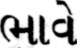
ભાવે
